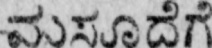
ಮಸೂದೆಗೆ
